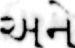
અને
